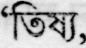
‘তিষ্য,
